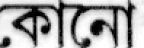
কোনো
